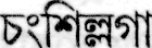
চংশিল্লগা
